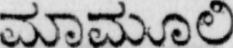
ಮಾಮೂಲಿ
